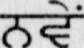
ਨਵੇਂ
